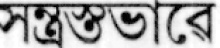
সন্ত্রস্তভাৱে
